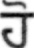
ਹੋ
